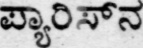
ಪ್ಯಾರಿಸ್ನ
